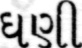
ઘણી
